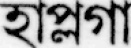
হাপ্লগা
